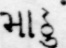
માઠું
